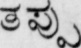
ತಪ್ಪು
